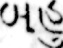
બહુ
